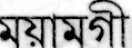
ময়ামগী
